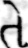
તે
